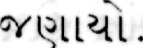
જણાયો.
